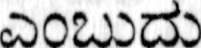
ಎಂಬುದು
